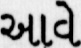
આવે
